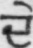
ਦੇ
